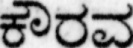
ಕೌರವ
